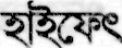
হাইফেৎ
